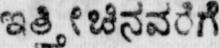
ಇತ್ತೀಚಿನವರೆಗೆ
